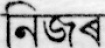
নিজৰ
